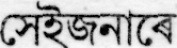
সেইজনাৰে
